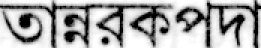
তান্নরকপদা
